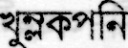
খুম্লকপনি
